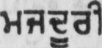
ਮਜਦੂਰੀ
